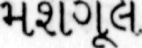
મશગૂલ
